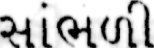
સાંભળી
